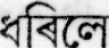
ধৰিলে
